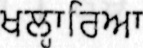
ਖਲ੍ਹਾਰਿਆ
